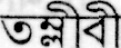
তম্লীবী
